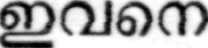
ഇവനെ
